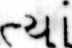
ત્યાં
